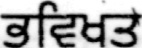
ਭਵਿਖਤ
